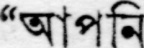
‘‘আপনি
